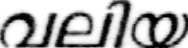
വലിയ
